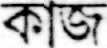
কাজ
